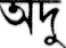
অদু
